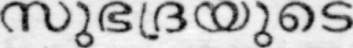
സുഭദ്രയുടെ
